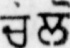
ਚਲੋ
